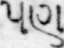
પણ
